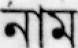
নাম
